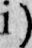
i)
